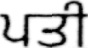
ਪਤੀ
